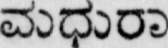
ಮಧುರಾ
